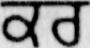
ਕਰ
